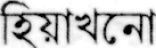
হিয়াখনো
